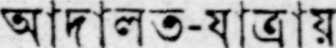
আদালত-যাত্রায়
